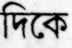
দিকে
